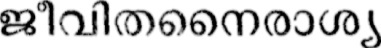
ജീവിതനൈരാശ്യ
